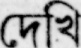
দেখি
